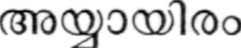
അയ്യായിരം
